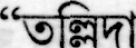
“তল্লিদা
